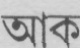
আক
